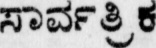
ಸಾರ್ವತ್ರಿಕ
